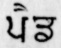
ਪੈਡ
